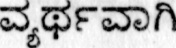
ವ್ಯರ್ಥವಾಗಿ
